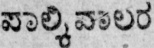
ಪಾಲ್ಕಿವಾಲರ
